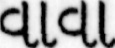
વાવા
